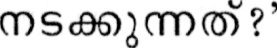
നടക്കുന്നത്?’
